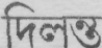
দিলন্ত
